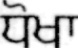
ਧੋਖਾ
